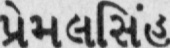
પ્રેમલસિંહ
